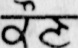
ਕੌਣ
